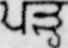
ਪੜ੍ਹ
